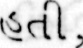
હતી,
